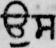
ਉਸ
